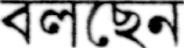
বলছেন
